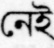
নেই
